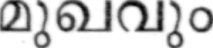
മുഖവും
